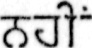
ਨਹੀਂ
